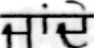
ਜਾਂਦੇ
